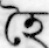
হৈ
